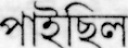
পাইছিল
